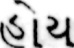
હોય
